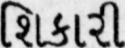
શિકારી
